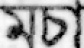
মচা
